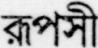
রূপসী
